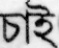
চাই
